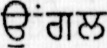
ਉਂਗਲ
